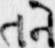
તને
